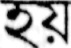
হয়
